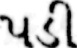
પડી
